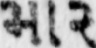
માર
